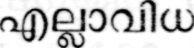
എല്ലാവിധ
